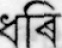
ধৰি
